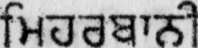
ਮਿਹਰਬਾਨੀ
